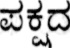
ಪಕ್ಷದ
